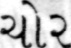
ચોર
